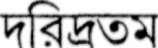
দরিদ্রতম
